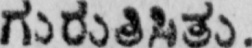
ಗುರುತಿಸಿತು.
